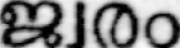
ജ്വരം
